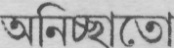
অনিচ্ছাতো
